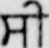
ਸੀ
